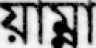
য়াম্না
